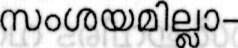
സംശയമില്ലാ-
